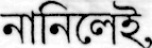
নানিলেই,
